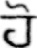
ਹੋ
